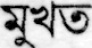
মুখত
